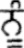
ਨੂੰ
